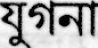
যুগনা
